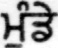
ਮੁੰਡੇ
